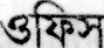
ওফিস
